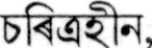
চৰিত্রহীন,
